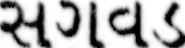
સગવડ
